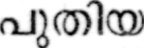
പുതിയ
